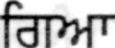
ਗਿਆ
